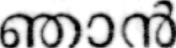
ഞാന്‍
